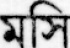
মসি
